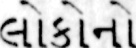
લોકોનો
